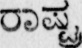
ರಾಷ್ಟ್ರ
